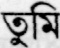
তুমি
